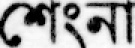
শেংনা
